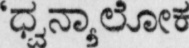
‘ಧ್ವನ್ಯಾಲೋಕ
